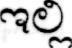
ಇಲ್ಲಿ
